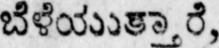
ಬೆಳೆಯುತ್ತಾರೆ,
